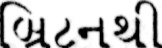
બ્રિટનથી
